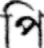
পি
